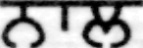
ਨਾਲ
